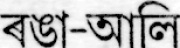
ৰঙা-আলি
